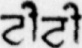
ਟੀਟੀ
